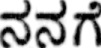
ನನಗೆ
